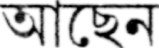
আছেন
